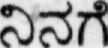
ನಿನಗೆ
